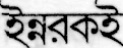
ইন্নরকই
